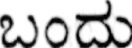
ಬಂದು
